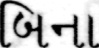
બિના
